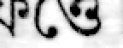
ফত্তে
